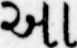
આ
